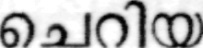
ചെറിയ
